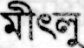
মীৎলু
